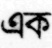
এক
